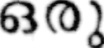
ഒരു
